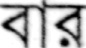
বার
